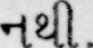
નથી.
